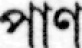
পাণ
